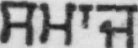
ਸਮਾਜ
